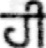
ਹੀ
